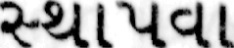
સ્થાપવા
